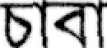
চাবা
